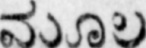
ಮೂಲ
